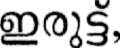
ഇരുട്ട്,
